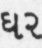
ઘર
